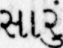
સારું
